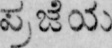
ಪ್ರಜೆಯ
